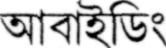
আবাইডিং
